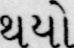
થયો
